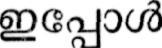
ഇപ്പോള്‍
